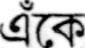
এঁকে
